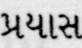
પ્રયાસ
